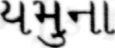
યમુના
